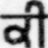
ਕੀ
